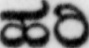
ಹರಿ
